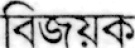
বিজয়ক
